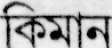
কিমান
